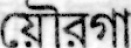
য়ৌরগা
